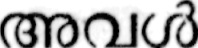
അവള്‍
